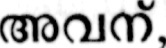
അവന്,
